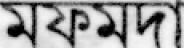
মফমদা
